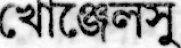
খোঞ্জেলসু
